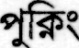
পুক্নিং
